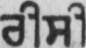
ਰੀਸੀ
